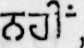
ਨਹੀਂ,
